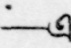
–এ
